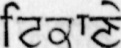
ਟਿਕਾਣੇ
